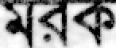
মরক
